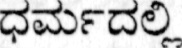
ಧರ್ಮದಲ್ಲಿ
